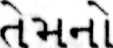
તેમનો
